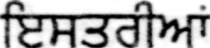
ਇਸਤਰੀਆਂ
